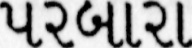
પરબારા
